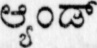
ಅಂಡ್
